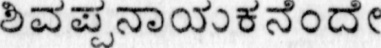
ಶಿವಪ್ಪನಾಯಕನೆಂದೇ
